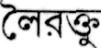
লৈরক্তু
